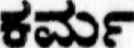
ಕರ್ಮ
